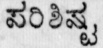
ಪರಿಶಿಷ್ಟ
